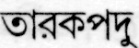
তারকপদু
